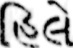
હિલે
